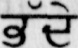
ਭੱਦੇ
